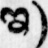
ಇ)
